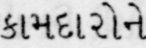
કામદારોને
